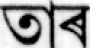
তাৰ
